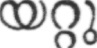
യറ്റു
